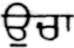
ਉਚਾ
